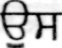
ਉਸ
